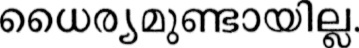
ധൈര്യമുണ്ടായില്ല.
